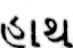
હાથ
